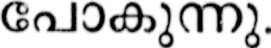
പോകുന്നു.
